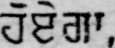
ਹੋਏਗਾ,
